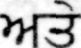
ਅਤੇ
